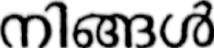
നിങ്ങള്‍
